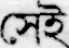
সেই
